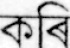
কৰি
